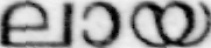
ലായ
